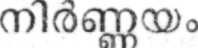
നിര്‍ണ്ണയം
